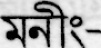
মনীং-
